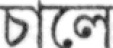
চালে
